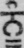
ਨੂੰ
